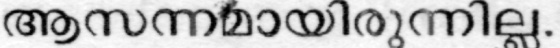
ആസന്നമായിരുന്നില്ല.
